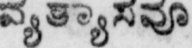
ವ್ಯತ್ಯಾಸವೂ
